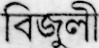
বিজুলী
